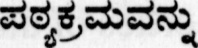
ಪಠ್ಯಕ್ರಮವನ್ನು
